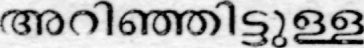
അറിഞ്ഞിട്ടുള്ള
